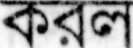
করল
